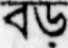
বড়
